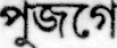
পুজগে
